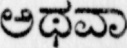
ಅಥವಾ
